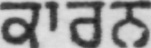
ਕਾਰਨ
